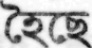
হৈছে
